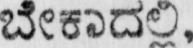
ಬೇಕಾದಲ್ಲಿ,
